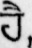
ਹੈ,
